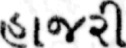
હાજરી
